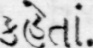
કહેતાં.
